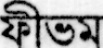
ফীভম
